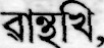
ৱান্থখি,
